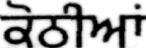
ਕੋਠੀਆਂ
